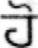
ਹੋ
